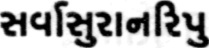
સર્વાસુરાનરિપુ
